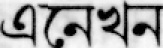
এনেখন
